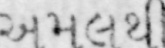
અમલથી
